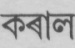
কৰাল
